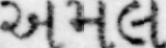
અમલ
